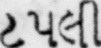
ટપલી
